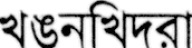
খঙনখিদরা
